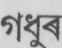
গধুৰ
